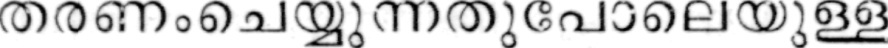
തരണംചെയ്യുന്നതുപോലെയുള്ള
